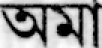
অমা
